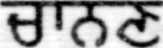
ਚਾਨਣ
